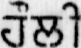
ਹੌਲੀ
